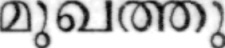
മുഖത്തു
